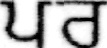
ਪਰ
